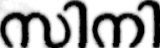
സിനി
